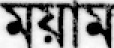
ময়াম
